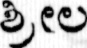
ಶ್ರೀಲ
